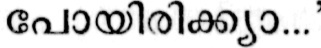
പോയിരിക്ക്യാ...’
